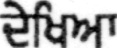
ਦੇਖਿਆ
